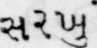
સરખું
